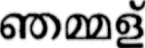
ഞമ്മള്
